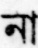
না
